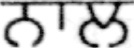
ਨਾਲ
